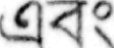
এবং
